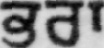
ਭਰਾ
